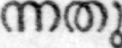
ന്നതു
